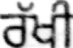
ਰੱਖੀ
